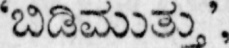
‘ಬಿಡಿಮುತ್ತು’,
